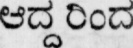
ಆದ್ದರಿಂದ
